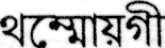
থম্মোয়গী
